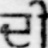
ਦੀ
